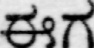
ಈಗ
